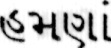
હમણાં
